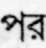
পর
